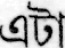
এটা
